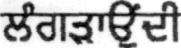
ਲੰਗੜਾਉਂਦੀ
